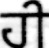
ਹੀ
